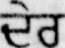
ਦੇਰ
